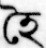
হৈ
